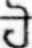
ਹੋ
